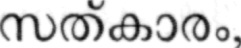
സത്കാരം,
